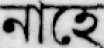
নাহে
